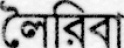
লৈরিবা
